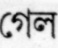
গেল
